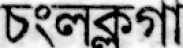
চংলক্লগা
